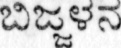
ಬಿಜ್ಜಳನ
